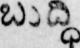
ಬುದ್ಧಿ
